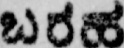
ಬರಹ
